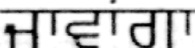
ਜਾਵਾਂਗਾ
